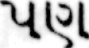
પણ
